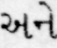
અને
